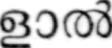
ളാല്‍
